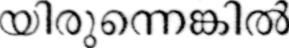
യിരുന്നെങ്കില്‍
